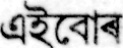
এইবোৰ
